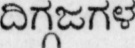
ದಿಗ್ಗಜಗಳ
